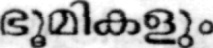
ഭൂമികളും
